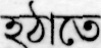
হঠাতে
